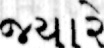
જ્યારે
